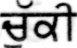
ਚੁੱਕੀ
